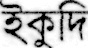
ইকুদি
